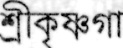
শ্রীকৃষ্ণগা
